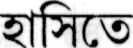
হাসিতে
